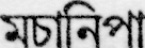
মচানিপা
